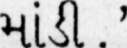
માંડી.'
